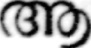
ആ
